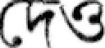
দেও
